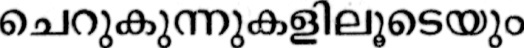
ചെറുകുന്നുകളിലൂടെയും
